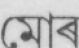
মোৰ
